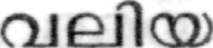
വലിയ
